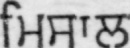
ਮਿਸਾਲ
